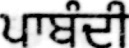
ਪਾਬੰਦੀ
